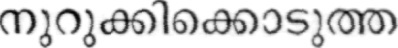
നുറുക്കിക്കൊടുത്ത
